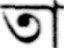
তা
